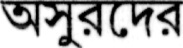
অসুরদের
